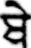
ਬੇ
